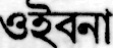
ওইবনা
